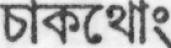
চাকথোং
